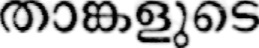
താങ്കളുടെ
